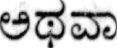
ಅಥವಾ
